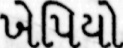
ખેપિયો
